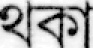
থকা
